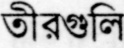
তীরগুলি
